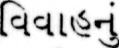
વિવાહનું
